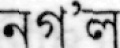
নগ'ল
